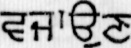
ਵਜਾਉਣ
